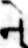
ને
